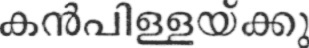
കന്‍പിള്ളയ്ക്കു
